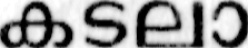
കടലാ
